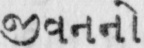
જીવનનો
